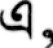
এ,
